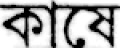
কাষে
